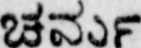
ಚರ್ಮ
